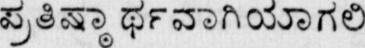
ಪ್ರತಿಷ್ಠಾರ್ಥವಾಗಿಯಾಗಲಿ
